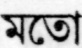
মতো
